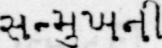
સન્મુખની
